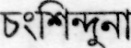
চংশিন্দুনা
